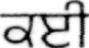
ਕਈ
